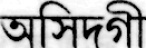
অসিদগী
